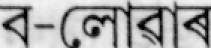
ব-লোৱাৰ
